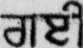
ਗਈ
